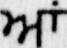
ਆਂ
